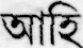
আহি
